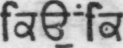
ਕਿਉਂਕਿ
